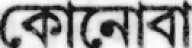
কোনোবা
